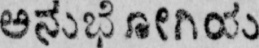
ಅನುಭೋಗಿಯ
